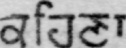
ਕਹਿਣਾ
